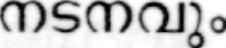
നടനവും
